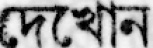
দেখোন
